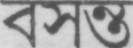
বসন্ত
